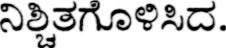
ನಿಶ್ಚಿತಗೊಳಿಸಿದ.
